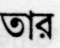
তার
